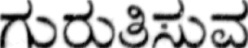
ಗುರುತಿಸುವ
